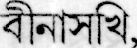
বীনাসখি,
